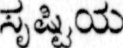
ಸೃಷ್ಟಿಯ
